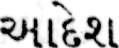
આદેશ
